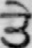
ਤੇ
